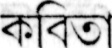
কবিতা
